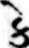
કે
